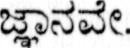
ಜ್ಞಾನವೇ.
